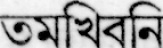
তমখিবনি
